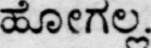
ಹೋಗಲ್ಲ.
